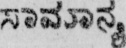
ಸಾಮಾನ್ಯ
